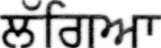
ਲੱਗਿਆ
